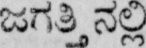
ಜಗತ್ತಿನಲ್ಲಿ
